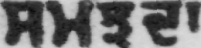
ਸਮਝਦਾ
